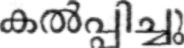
കല്‍പ്പിച്ചു
